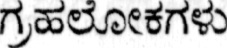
ಗ್ರಹಲೋಕಗಳು
